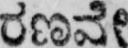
ರಣವೇ
